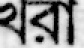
খরা
